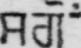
ਸਗੋਂ
